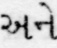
અને
